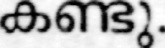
കണ്ടു.
